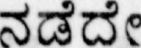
ನಡೆದೇ
